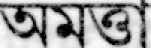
অমত্তা
